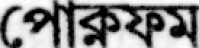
পোক্নফম
